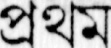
প্রথম
